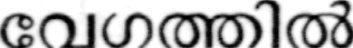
വേഗത്തില്‍
